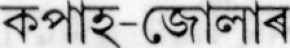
কপাহ-জোলাৰ
